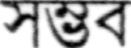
সম্ভব
